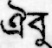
ঐবু
